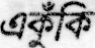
একুঁকি
